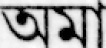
অমা
